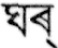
ঘৰ্
